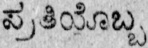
ಪ್ರತಿಯೊಬ್ಬ
